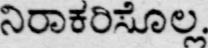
ನಿರಾಕರಿಸೊಲ್ಲ.
